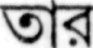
তার
